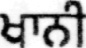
ਖਾਨੀ
